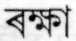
ৰক্ষা
